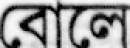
বোলে
